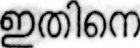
ഇതിനെ
